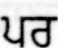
ਪਰ
